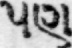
પણ
